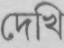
দেখি
